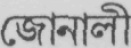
জোনালী
